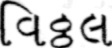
વિઠ્ઠલ
